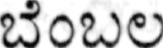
ಬೆಂಬಲ
